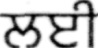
ਲਈ
